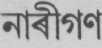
নাৰীগণ
